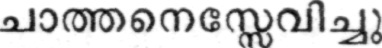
ചാത്തനെസ്സേവിച്ചു
